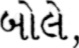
બોલે,
